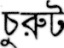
চুরুট
